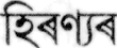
হিৰণ্যৰ
